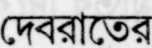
দেবরাতের
